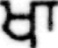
ਖਾ
